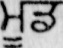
ਮੂਡ
